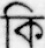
কি
